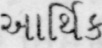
આર્થિક
